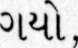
ગયો,
